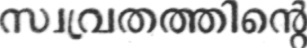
സ്വവ്രതത്തിന്റെ
